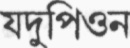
যদুপিওন
